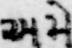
અમે
